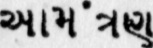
આમંત્રણ
